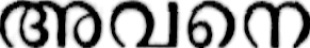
അവനെ
